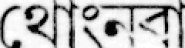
থোংনবা
